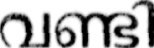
വണ്ടി
